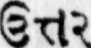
ઉત્તર
